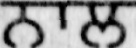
ਨਾਲ
